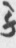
કે
